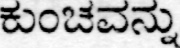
ಕುಂಚವನ್ನು
